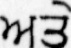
ਅਤੇ
